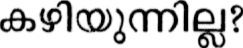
കഴിയുന്നില്ല?
